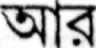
আর
